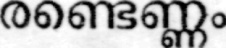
രണ്ടെണ്ണം
